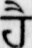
ਹੈ
